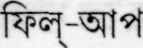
ফিল্‌-আপ
